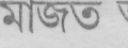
মাজত
